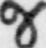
જ
